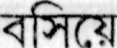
বসিয়ে
